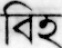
বিহ
